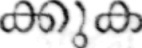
ക്കുക
